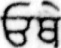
ਓਥੇ
